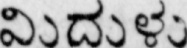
ಮಿದುಳು
